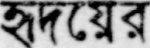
হৃদয়ের
